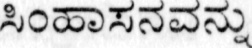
ಸಿಂಹಾಸನವನ್ನು
